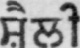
ਸ਼ੈਲੀ
